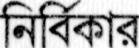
নির্বিকার
